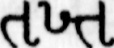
તખ્ત
